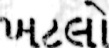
ખટલો
